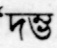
‘দম্ভ
